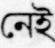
নেই
